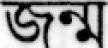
জন্ম
